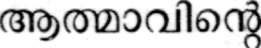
ആത്മാവിന്റെ
